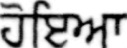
ਹੋਇਆ
